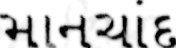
માનચાંદ
